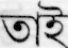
তাই
